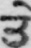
ਤੇ
